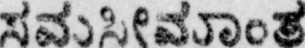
ಸಮಸೀಮಾಂತ
